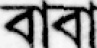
বাবা
